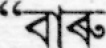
"বাৰু
